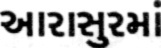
આરાસુરમાં
